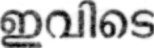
ഇവിടെ
